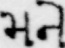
મને
